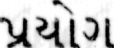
પ્રયોગ
